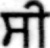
ਸੀ
